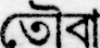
তৌবা
